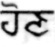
ਹੋਣ
